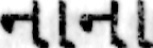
નાના
